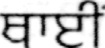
ਥਾਈਂ
